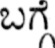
ಬಗ್ಗೆ
